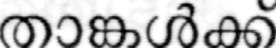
താങ്കള്‍ക്ക്
